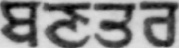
ਬਣਤਰ
